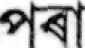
পৰা
